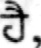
ਹੈ,
